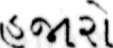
હજારો
